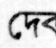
দেব
